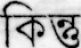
কিন্তু
